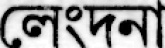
লেংদনা
